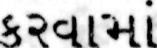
કરવામાં
